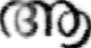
ആ
